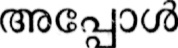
അപ്പോള്‍
